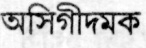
অসিগীদমক
